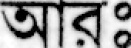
আরঃ
